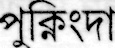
পুক্নিংদা
